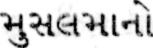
મુસલમાનો
